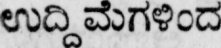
ಉದ್ದಿಮೆಗಳಿಂದ
